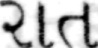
રાત
